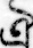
ঐ
